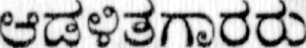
ಆಡಳಿತಗಾರರು
